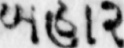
બહાર
